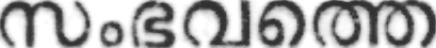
സംഭവത്തെ
